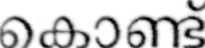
കൊണ്ട്
